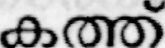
കത്ത്
